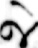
જે
